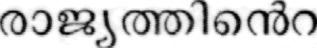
രാജ്യത്തിന്റെ
